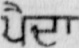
ਪੈਦਾ
